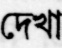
দেখা
